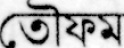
তৌফম
